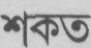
শকত
